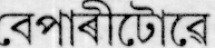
বেপাৰীটোৱে
